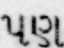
પણ
